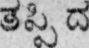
ತಪ್ಪಿದ
